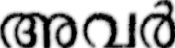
അവര്‍
